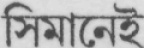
সিমানেই
